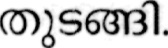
തുടങ്ങി.
